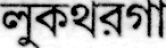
লুকথরগা
